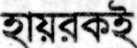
হায়রকই
